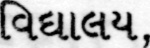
વિધાલય,
